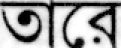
তারে
